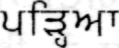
ਪੜ੍ਹਿਆ
